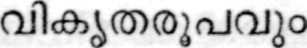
വികൃതരൂപവും
